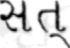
સત્
